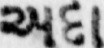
અદા
